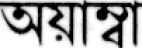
অয়াম্বা
